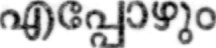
എപ്പോഴും
